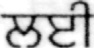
ਲਈ
